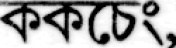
ককচেং,
